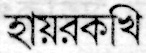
হায়রকখি
